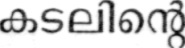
കടലിന്റെ
